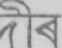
দীৰ
